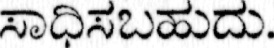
ಸಾಧಿಸಬಹುದು.
